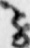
કે
